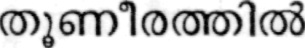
തൂണീരത്തില്‍
